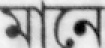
মানে
